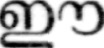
ഈ
